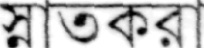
স্নাতকরা
